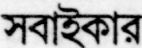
সবাইকার
